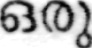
ഒരു
